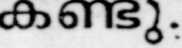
കണ്ടു.
